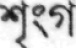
শৃংগ
